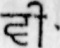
ਵੀ
